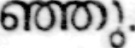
ഞ്ഞു.
